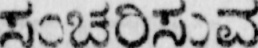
ಸಂಚರಿಸುವ
